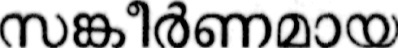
സങ്കീര്‍ണമായ
